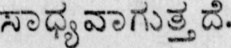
ಸಾಧ್ಯವಾಗುತ್ತದೆ.
